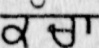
ਕੱਚਾ
